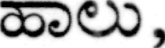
ಹಾಲು,
